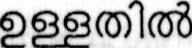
ഉള്ളതില്‍
